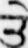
ਤੇ
